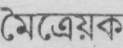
মৈত্ৰেয়ক
